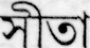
সীতা
